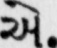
એ.
